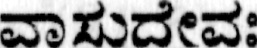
ವಾಸುದೇವಃ
